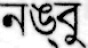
নঙবু
